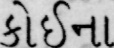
કોઈના
